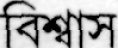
বিশ্বাস
